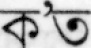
ক'ত
